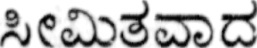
ಸೀಮಿತವಾದ
